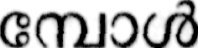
മ്പോള്‍
